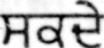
ਸਕਦੇ
